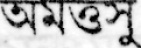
অমত্তসু
